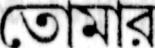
তোমার
